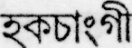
হকচাংগী
